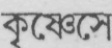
কৃষ্ণেসে
